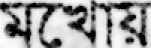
মখোয়
